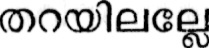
തറയിലല്ലേ
